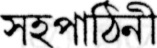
সহপাঠিনী
